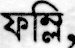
ফম্লি,
